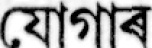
যোগাৰ
